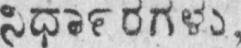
ನಿರ್ಧಾರಗಳು,
